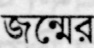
জন্মের
